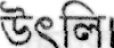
উৎলি।
